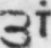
ਤਾਂ
